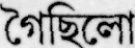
গৈছিলো
